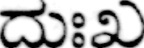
ದುಃಖ
